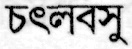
চৎলবসু
